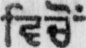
ਵਿਚੋਂ
